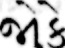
જોકે
